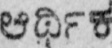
ಆರ್ಥಿಕ
